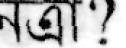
নত্রা?
